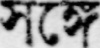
সঙ্গে
